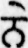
ਨੇ
